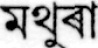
মথুৰা
